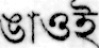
ঙাওই
